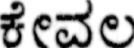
ಕೇವಲ
